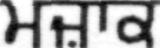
ਮਜ਼ਾਕ
